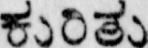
ಕುರಿತು
